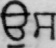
ਉਸ
